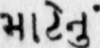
માટેનું
